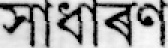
সাধাৰণ
